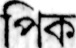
পিক
